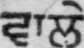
ਵਾਲੇ
